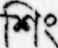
শিং
